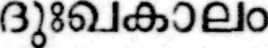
ദുഃഖകാലം
